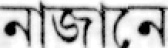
নাজানে
